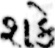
શકે
